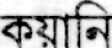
কয়ানি
